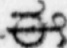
ಈ
